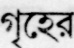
গৃহের
